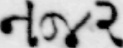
નજર
